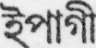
ইপাগী
